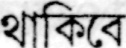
থাকিবে
